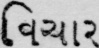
વિચાર
